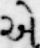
એ
